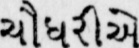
ચૌધરીએ
